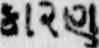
કારણ
